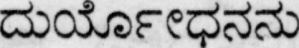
ದುರ್ಯೋಧನನು
